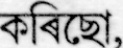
কৰিছো,
